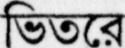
ভিতরে
